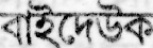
বাইদেউক
